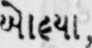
બોલ્યા,
